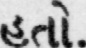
હતો.
